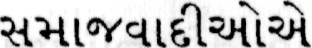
સમાજવાદીઓએ
